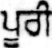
ਪੂਰੀ
